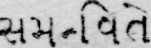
સમન્વિતે
